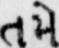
તમે
